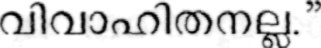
വിവാഹിതനല്ല.”
